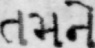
તમને
